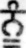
ਨੂੰ
